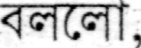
বললো,
